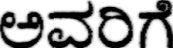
ಅವರಿಗೆ
